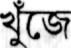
খুঁজে
